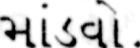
માંડવો.
